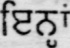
ਇਨ੍ਹਾਂ
